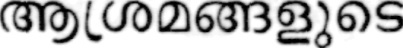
ആശ്രമങ്ങളുടെ
